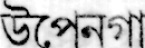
উপেনগা
